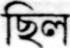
ছিল
